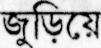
জুড়িয়ে
